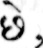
છે,
